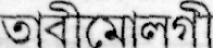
তাবীমোলগী
